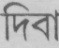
দিবা
